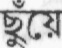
ছুঁয়ে
